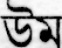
উম
